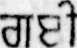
ਗਈ
